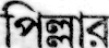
পিল্লার
